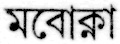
মবোক্না
